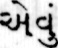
એવું
